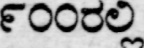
೯೦೦ರಲ್ಲಿ
